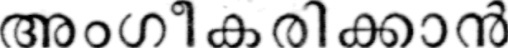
അംഗീകരിക്കാന്‍
